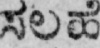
ಸಲಹೆ
